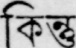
কিন্তু
